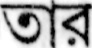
তার
